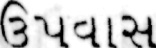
ઉપવાસ
